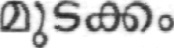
മുടക്കം
